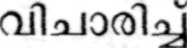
വിചാരിച്ച്
